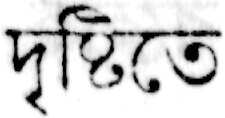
দৃষ্টিতে
